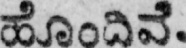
ಹೊಂದಿದೆ.
